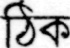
ঠিক
